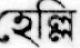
হেল্লি
